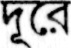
দূরে
